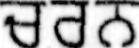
ਚਰਨ
